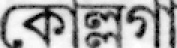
কোল্লগা
